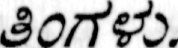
ತಿಂಗಳು.
